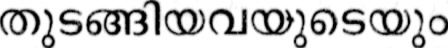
തുടങ്ങിയവയുടെയും
